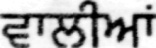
ਵਾਲੀਆਂ
